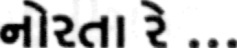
રે....
